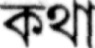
কথা
